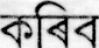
কৰিব
